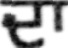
ਦਾ
